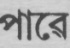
পাৱে
